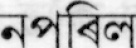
নপৰিল
